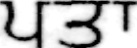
ਪਤਾ
